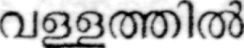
വള്ളത്തില്‍
